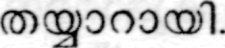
തയ്യാറായി.
